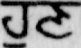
ਹੁਣ
